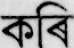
কৰি
